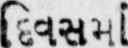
દિવસમાં
